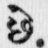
છે.
